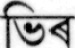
ভিৰ
